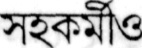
সহকর্মীও
